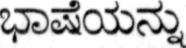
ಭಾಷೆಯನ್ನು
